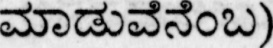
ಮಾಡುವೆನೆಂಬ)
